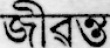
জীৱন্ত
